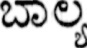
ಬಾಲ್ಯ
